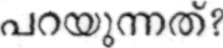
പറയുന്നത്?
